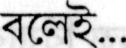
বলেই...
